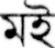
মই
